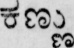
ಕಣ್ಣು
